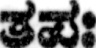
ತಪಃ
